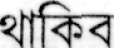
থাকিব
